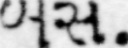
બસ.
